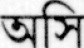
অসি
